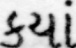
ક્યાં
